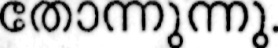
തോന്നുന്നു.
